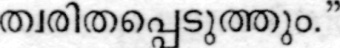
ത്വരിതപ്പെടുത്തും.”
